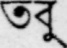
তবু
